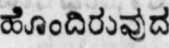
ಹೊಂದಿರುವುದ
